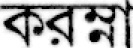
করম্না
